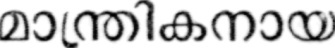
മാന്ത്രികനായ
